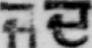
ਜਦ
